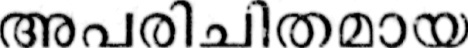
അപരിചിതമായ
